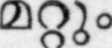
മറ്റും
